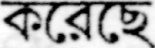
করেছে
